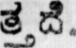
ತ್ತದೆ.
